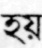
হয়
